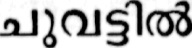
ചുവട്ടില്‍
